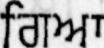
ਗਿਆ
